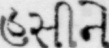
હસીને
